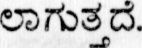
ಲಾಗುತ್ತದೆ.
